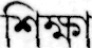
শিক্ষা
